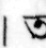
। ত
